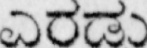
ಎರಡು
